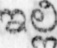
ಇಲ್ಲಿ
